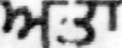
ਅਤਾ
